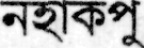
মফম
